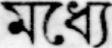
মধ্যে
